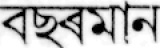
বছৰমান
